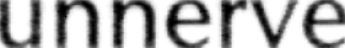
unnerve
